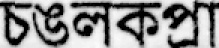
চঙলকপ্রা
